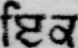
ਇਕ
